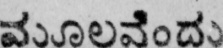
ಮೂಲವೆಂದು
